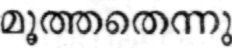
മൂത്തതെന്നു
